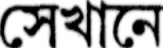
সেখানে
